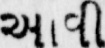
આવી
